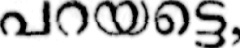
പറയട്ടെ,
